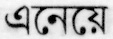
এনেয়ে
